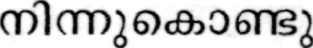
നിന്നുകൊണ്ടു
